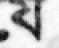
যে
